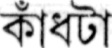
কাঁধটা
